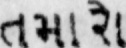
તમારો
